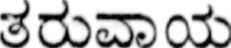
ತರುವಾಯ
